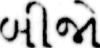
બીજો
